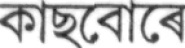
কাছবোৰে
